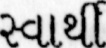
સ્વાર્થી
